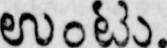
ಉಂಟು.
